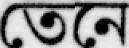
তেনে
